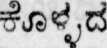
ಕೊಳ್ಳದ
